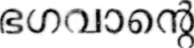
ഭഗവാന്റെ
